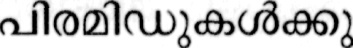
പിരമിഡുകള്‍ക്കു
